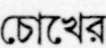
চোখের
